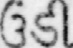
ઉંડી
